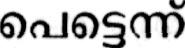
പെട്ടെന്ന്
